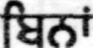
ਬਿਨਾਂ
